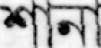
শানা
